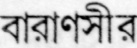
বারাণসীর
